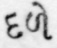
દળે
